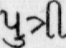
પુત્રી
